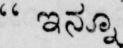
“ಇನ್ನೂ
